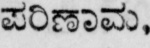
ಪರಿಣಾಮ,
